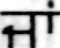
ਜਾਂ
